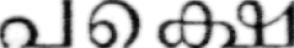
പക്ഷെ
